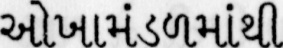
ઓખામંડળમાંથી
